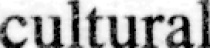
cultural
